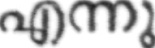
എന്നു
